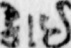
કોઈ
